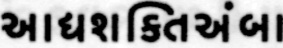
આધશક્તિઅંબા
